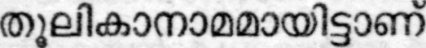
തൂലികാനാമമായിട്ടാണ്
